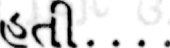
હતી....
